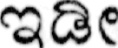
ಇಡೀ
